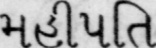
મહીપતિ
